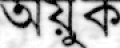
অয়ুক
